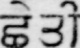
ਛੇਤੀ
